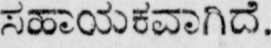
ಸಹಾಯಕವಾಗಿದೆ.
